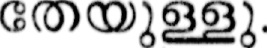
തേയുള്ളു.
